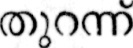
തുറന്ന്
